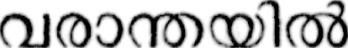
വരാന്തയില്‍
